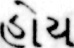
હોય
